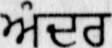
ਅੰਦਰ
